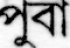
পুবা
